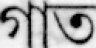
গাত
